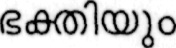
ഭക്തിയും
